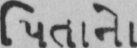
પિતાનો
